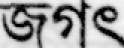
জগৎ
